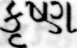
કૃષ્ણ
